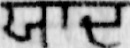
ਯਾਦ
